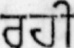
ਰਹੀ
